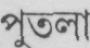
পুতলা
